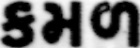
કમળ
